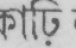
কাঢ়ি
